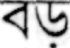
বড়
